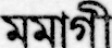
মমাগী
